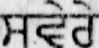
ਸਵੇਰੇ
